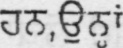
ਹਨ,ਉਨ੍ਹਾਂ
